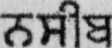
ਨਸੀਬ
